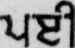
ਪਈ
